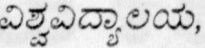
ವಿಶ್ವವಿದ್ಯಾಲಯ,
